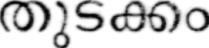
തുടക്കം
